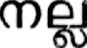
നല്ല
